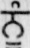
ਨੂੰ
